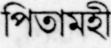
পিতামহী
